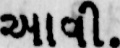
આવી.
